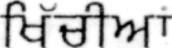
ਖਿੱਚੀਆਂ
